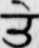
ਤੇ
